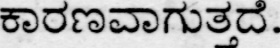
ಕಾರಣವಾಗುತ್ತದೆ.
